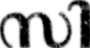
സി
